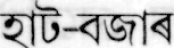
হাট-বজাৰ
